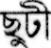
ছুটী
